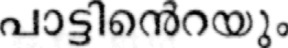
പാട്ടിന്റെയും
